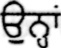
ਉਨ੍ਹਾਂ
